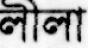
লীলা
